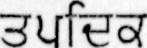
ਤਪਦਿਕ
